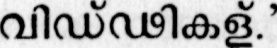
വിഡ്ഢികള്.’
